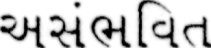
અસંભવિત
